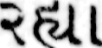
રહ્યા
